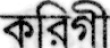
করিগী
